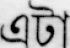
এটা
